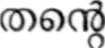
തന്റെ
